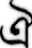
ঐ
